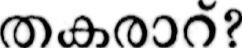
തകരാറ്?
